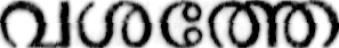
വശത്തേ
